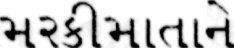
મરકીમાતાને
